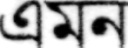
এমন
